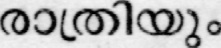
രാത്രിയും
